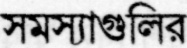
সমস্যাগুলির
